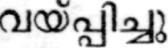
വയ്പ്പിച്ചു
